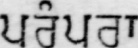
ਪਰੰਪਰਾ
